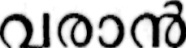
വരാന്‍
